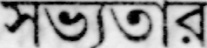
সভ্যতার
